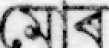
মোৰ
